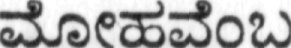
ಮೋಹವೆಂಬ
